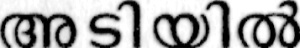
അടിയില്‍
